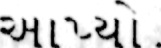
આપ્યો.
